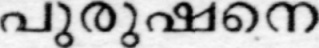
പുരുഷനെ
